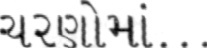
ચરણોમાં...
